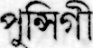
পুন্সিগী
